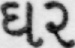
ઘર
